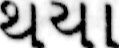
થયા
